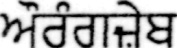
ਔਰੰਗਜ਼ੇਬ
